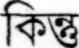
কিন্তু
